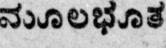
ಮೂಲಭೂತ
